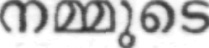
നമ്മുടെ
